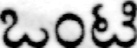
ಒಂಟಿ
